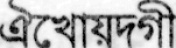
ঐখোয়দগী
